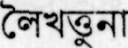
লৈখত্তুনা
